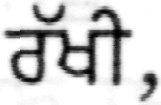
ਰੱਖੀ,
